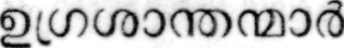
ഉഗ്രശാന്തന്മാര്‍
